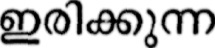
ഇരിക്കുന്ന
